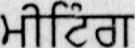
ਮੀਟਿੰਗ
